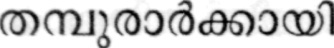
തമ്പുരാര്‍ക്കായി
